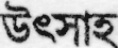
উৎসাহ
